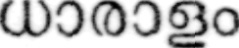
ധാരാളം
